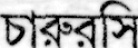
চারুরসি
